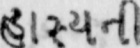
હાસ્યની
